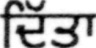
ਦਿੱਤਾ
